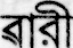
ৱারী
